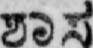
ಶಾಸ
